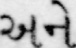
અને
